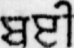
ਬਈ
